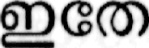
ഇതേ
